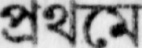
প্রথমে
